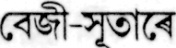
বেজী-সূতাৰে
